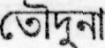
তৌদুনা
